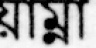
য়াম্না
